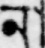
না
